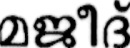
മജീദ്
